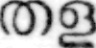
തള
